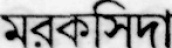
মরকসিদা
